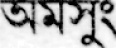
অমসুং
